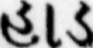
હાડ
